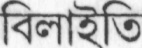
বিলাইতি
